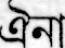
ঐনা
